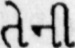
તેની
